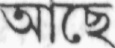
আছে
